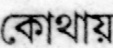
কোথায়
